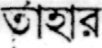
তাহার
